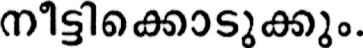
നീട്ടിക്കൊടുക്കും.
